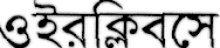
ওইরক্লিবসে
